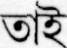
তাই
